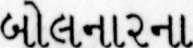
બોલનારના
